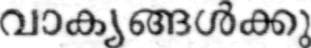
വാക്യങ്ങള്‍ക്കു
